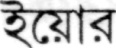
ইয়োর
